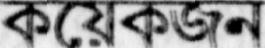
কয়েকজন
